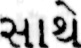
સાથે
